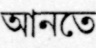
আনতে
